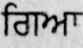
ਗਿਆ
